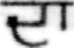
ਦਾ
